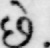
છે.
